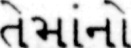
તેમાંનો
